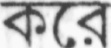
করে
